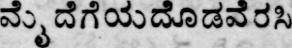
ಮೈದೆಗೆಯದೊಡವೆರಸಿ
